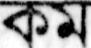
কম
